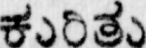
ಕುರಿತು
